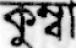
কুম্বা
